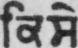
ਕਿਸੇ
